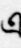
এ
